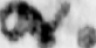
જ.
